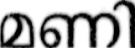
മണി
